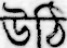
উঠি
